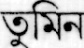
তুমিন
